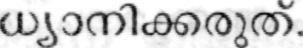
ധ്യാനിക്കരുത്.
